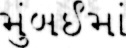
મુંબઈમાં
